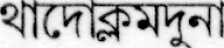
থাদোক্লমদুনা
